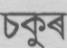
চকুৰ
